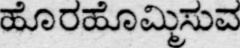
ಹೊರಹೊಮ್ಮಿಸುವ
